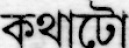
কথাটো
